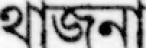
থাজনা
